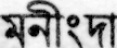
মনীংদা
